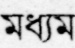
মধ্যম
